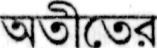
অতীতের
